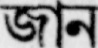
জান
